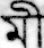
মী
